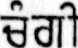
ਚੰਗੀ
